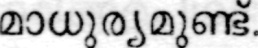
മാധുര്യമുണ്ട്.
